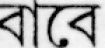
বাবে
